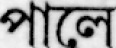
পালে
